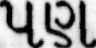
પણ
